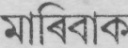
মাৰিবাক
